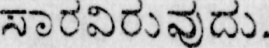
ಸಾರವಿರುವುದು.
